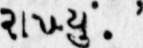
રાખ્યું.'
